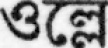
ওল্লে
